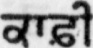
ਕਾਫ਼ੀ
